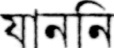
যাননি
